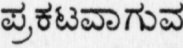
ಪ್ರಕಟವಾಗುವ
